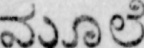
ಮೂಲೆ
